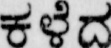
ಕಳೆದ
